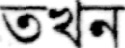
তখন
